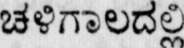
ಚಳಿಗಾಲದಲ್ಲಿ
